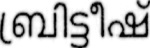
ബ്രിട്ടീഷ്
